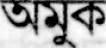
অমুক
